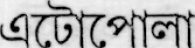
এটোপোলা
